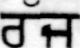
ਰੱਜ
